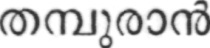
തമ്പുരാന്‍
